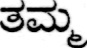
ತಮ್ಮ
